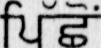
ਪਿੱਛੋਂ
